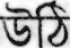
উঠি
